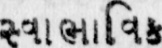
સ્વાભાવિક
